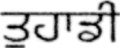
ਤੁਹਾਡੀ
